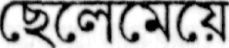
ছেলেমেয়ে
